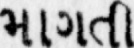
માગતી
